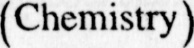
(Chemistry)
